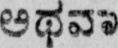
ಅಥವಾ
